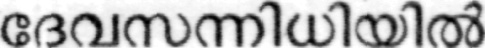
ദേവസന്നിധിയില്‍
